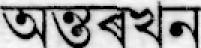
অন্তৰখন
